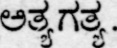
ಅತ್ಯಗತ್ಯ.
